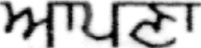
ਆਪਣਾ
